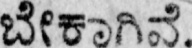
ಬೇಕಾಗಿವೆ.
